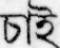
চাই
